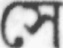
সে
